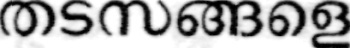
തടസങ്ങളെ
